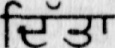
ਦਿੱਤਾ
